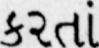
કરતાં
